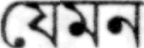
যেমন
